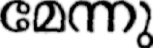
മേന്നു
